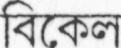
বিকেল
